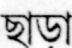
ছাড়া
